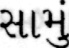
સામું
